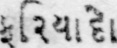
ફરિયાદો
